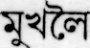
মুখলৈ
